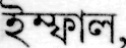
ইম্ফাল,
